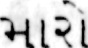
મારો
